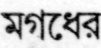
মগধের
